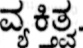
ವ್ಯಕ್ತಿತ್ವ.
